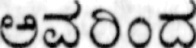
ಅವರಿಂದ
